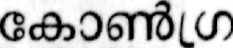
കോണ്‍ഗ്ര
